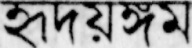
হৃদয়ঙ্গম
